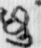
છું
